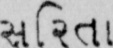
સરિતા
